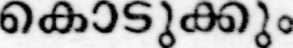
കൊടുക്കും
